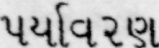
પર્યાવરણ
